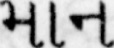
માન
